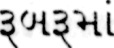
રૂબરૂમાં
